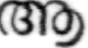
ആ
